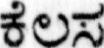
ಕೆಲಸ
